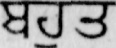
ਬਹੁਤ
